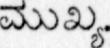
ಮುಖ್ಯ.
